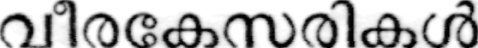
വീരകേസരികള്‍
